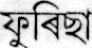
ফুৰিছা
